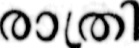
രാത്രി
